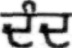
ਦੰਦ
